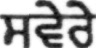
ਸਵੇਰੇ
